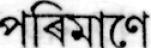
পৰিমাণে
